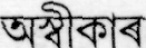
অস্বীকাৰ
